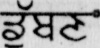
ਡੁੱਬਣ
